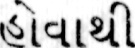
હોવાથી
